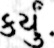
કર્યું.
